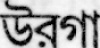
উরগা
